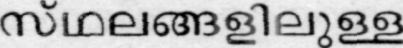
സ്ഥലങ്ങളിലുള്ള
